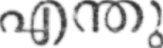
എന്തു
